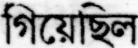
গিয়েছিল
